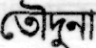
তৌদুনা
